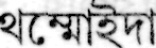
থম্মোইনা
